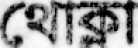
থোক্না
